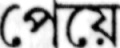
পেয়ে
